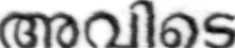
അവിടെ
